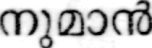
നുമാന്‍
